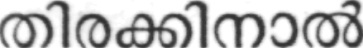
തിരക്കിനാല്‍
